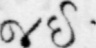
જઈ
